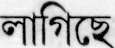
লাগিছে
